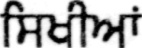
ਸਿਖੀਆਂ
